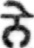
ਨੇ
